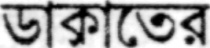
ডাকাতের
